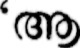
'ആ
